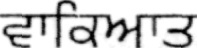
ਵਾਕਿਆਤ
